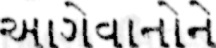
આગેવાનોને
